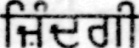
ਜ਼ਿੰਦਗੀ
